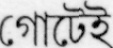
গোটেই
